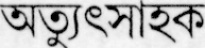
অত্যুৎসাহক
